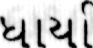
ધાર્યા
